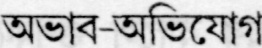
অভাব-অভিযোগ
